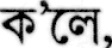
ক'লে,
